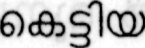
കെട്ടിയ
